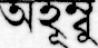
অহূম্বু
